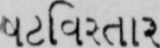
ષટવિસ્તાર
